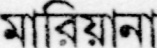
মারিয়ানা
